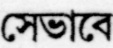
সেভাবে
